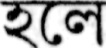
হলে
